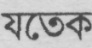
যতেক
